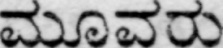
ಮೂವರು
